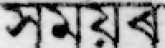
সময়ৰ
